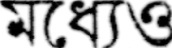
মধ্যেও
